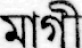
মাগী
